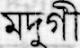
মদুগী
